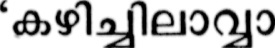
‘കഴിച്ചിലാവ്വാ
